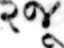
રજૂ
